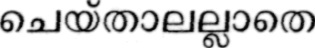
ചെയ്താലല്ലാതെ
